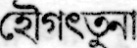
হৌগৎতুনা
